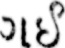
ગઈ
